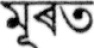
মূৰত
